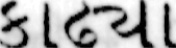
કાઢ્યા
